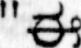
“ಈ
